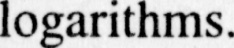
logarithms,
